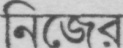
নিজের
